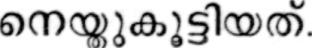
നെയ്തുകൂട്ടിയത്.
